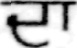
ਦਾ
